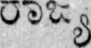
ರಾಜ್ಯ
